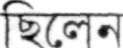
ছিলেন
